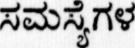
ಸಮಸ್ಯೆಗಳ
